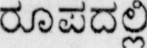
ರೂಪದಲ್ಲಿ
